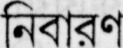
নিবারণ
